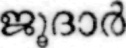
ജൂദാര്‍
